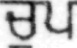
ਚੁਪ
